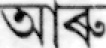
আৰু
